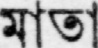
মাতা
